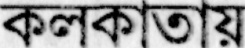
কলকাতায়
